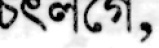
চৎলগে,
